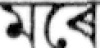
মৰে
